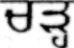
ਚੜ੍ਹ
